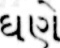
ઘણે
